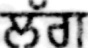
ਲੱਗ
